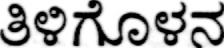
ತಿಳಿಗೊಳನ
